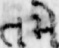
તમે
